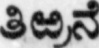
ತಿಱ್ರನೆ
